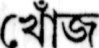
খোঁজ
